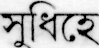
সুধিহে
